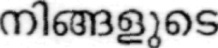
നിങ്ങളുടെ
